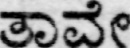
ತಾವೇ
